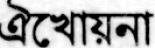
ঐখোয়না
